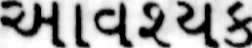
આવશ્યક
